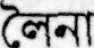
লৈনা
